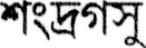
শংদ্রগসু
